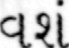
વશં
